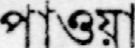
পাওয়া
